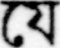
যে
